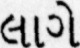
લાગે
